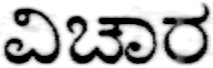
ವಿಚಾರ
